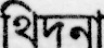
থিদনা
